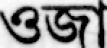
ওজা
